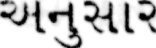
અનુસાર
